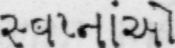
સ્વપ્નાંઓ
